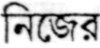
নিজের
